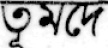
তূমদে
